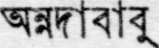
অন্নদাবাবু
